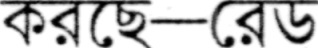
করছে–রেড
